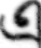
এ
